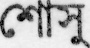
শোসু
